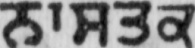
ਨਾਸਤਕ
